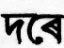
দৰে
